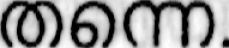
തന്നെ.
